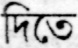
দিতে
